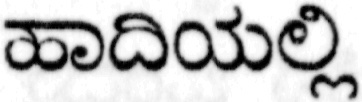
ಹಾದಿಯಲ್ಲಿ
